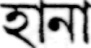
হানা
